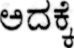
ಅದಕ್ಕೆ
